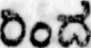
ರಿಂದ
